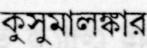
কুসুমালঙ্কার
